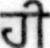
ਹੀ
